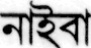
নাইবা
